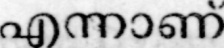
എന്നാണ്
